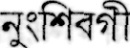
নুংশিবগী
